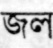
জল
